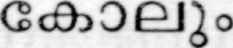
കോലും
